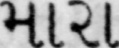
મારા
